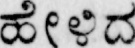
ಹೇಳಿದ
